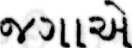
જગાએ
